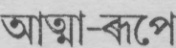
আত্মা-ৰূপে
